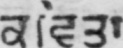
ਕਵਿਤਾ
